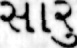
સારુ
